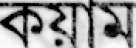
কয়াম
